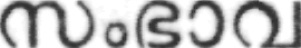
സംഭാവ
